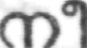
നീ
